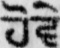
ਹੋਵੇ
